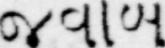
જવાબ
